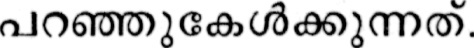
പറഞ്ഞുകേള്‍ക്കുന്നത്.
